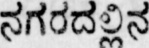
ನಗರದಲ್ಲಿನ
